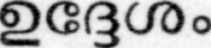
ഉദ്ദേശം
